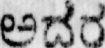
ಅದರ
